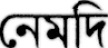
নেমদি
